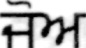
ਜੋਅ
